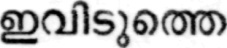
ഇവിടുത്തെ
